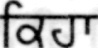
ਕਿਹਾ
